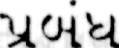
પ્રબંધ
